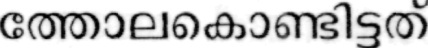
ത്തോലകൊണ്ടിട്ടത്
